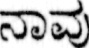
ನಾವು
